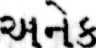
અનેક
